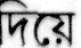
দিয়ে
